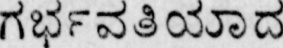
ಗರ್ಭವತಿಯಾದ
